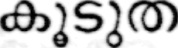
കൂടുത
